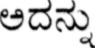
ಅದನ್ನು
